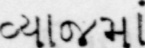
વ્યાજમાં
